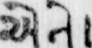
એનો
